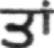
ਤਾਂ
